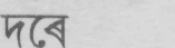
দৰে
